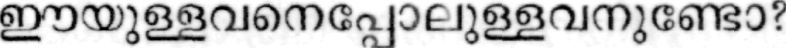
ഈയുള്ളവനെപ്പോലുള്ളവനുണ്ടോ?
